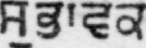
ਸੁਭਾਵਕ
